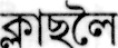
ক্লাছলৈ
